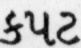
કપટ
